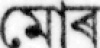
মোৰ
